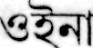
ওইনা
